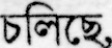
চলিছে,
